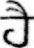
ਹੈ
